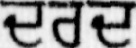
ਦਰਦ
